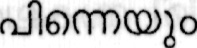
പിന്നെയും
